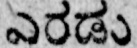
ಎರಡು
